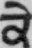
ਕੇ
